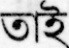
তাই
